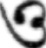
ও
